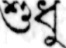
শুধু
